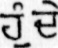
ਹੁੰਦੇ
